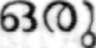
ഒരു
